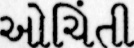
ઓચિંતી
